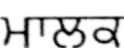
ਮਾਲਕ
